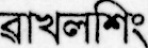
ৱাখলশিং
